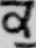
ਕੁ
